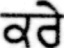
ਕਰੇ
